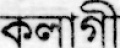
কলাগী
